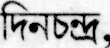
দিনচন্দ্র,
